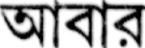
আবার
